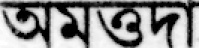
অমত্তদা
